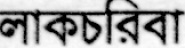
লাকচরিবা
